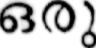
ഒരു
